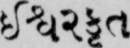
ઇશ્વરકૃત
